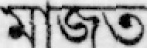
মাজত
